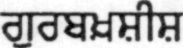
ਗੁਰਬਖ਼ਸ਼ੀਸ਼
